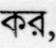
কর,
